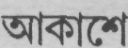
আকাশে
